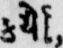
કર્યો.
